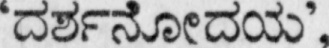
‘ದರ್ಶನೋದಯ’,
